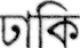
ঢাকি
